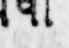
થવો
